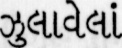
ઝુલાવેલાં
